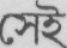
সেই
